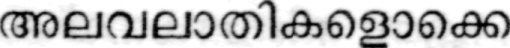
അലവലാതികളൊക്കെ
